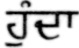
ਹੁੰਦਾ
